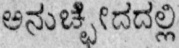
ಅನುಚ್ಛೇದದಲ್ಲಿ
